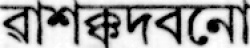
ৱাশক্কদবনো
